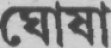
ঘোষা
